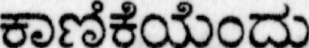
ಕಾಣಿಕೆಯೆಂದು
